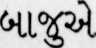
બાજુએ
